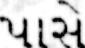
પાસે
